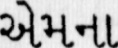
એમના
